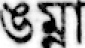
ঙম্না
